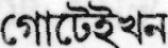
গোটেইখন
